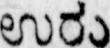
ಉರು
